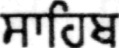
ਸਾਹਿਬ
